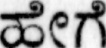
ಹೇಗೆ
